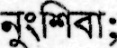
নুংশিবা;
